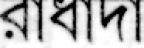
রাধাদা
